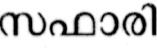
സഫാരി
